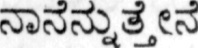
ನಾನೆನ್ನುತ್ತೇನೆ
